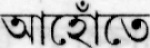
আহোঁতে
